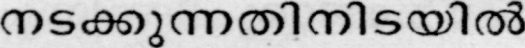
നടക്കുന്നതിനിടയില്‍
